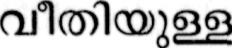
വീതിയുള്ള
